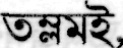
তম্লকই,
